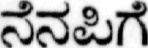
ನೆನಪಿಗೆ
